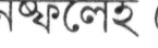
নিষ্ফলেই
